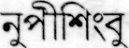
নুপীশিংবু
